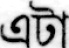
এটা
